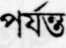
পর্যন্ত
